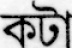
কটা
